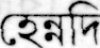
হেন্নদি
